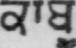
ਕਾਬੂ
